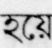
হয়ে
